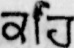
ਕਹਿ
